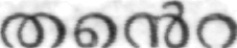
തന്റെ
